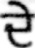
ਦੇ
